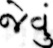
જેવું
